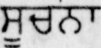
ਸੂਚਨਾ
